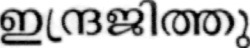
ഇന്ദ്രജിത്തു
